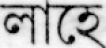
লাহে
